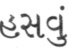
હસવું
